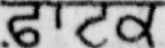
ਫ਼ਾਟਕ
